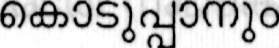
കൊടുപ്പാനും
